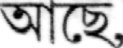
আছে,
